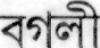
বগলী
